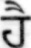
ਹੈ
